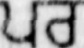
ਪਰ
